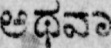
ಅಥವಾ
